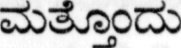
ಮತ್ತೊಂದು
